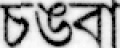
চঙবা
